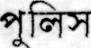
পুলিস
